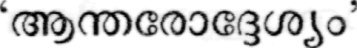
'ആന്തരോദ്ദേശ്യം'
